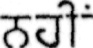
ਨਹੀਂ
